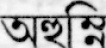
অহুম্নি
